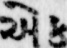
એક
